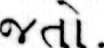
જતો.
